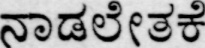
ನಾಡಲೇತಕೆ
